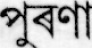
পুৰণা
